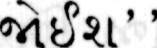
જોઈશ"
